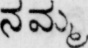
ನಮ್ಮ
